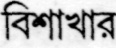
বিশাখার
